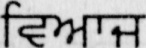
ਵਿਆਜ
